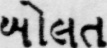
બોલત
